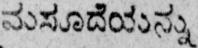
ಮಸೂದೆಯನ್ನು
